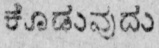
ಕೊಡುವುದು
